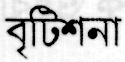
বৃটিশনা
